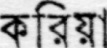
করিয়া
